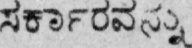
ಸರ್ಕಾರವನ್ನು
